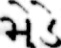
મેડે
